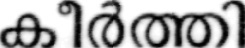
കീര്‍ത്തി
